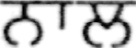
ਨਾਲ
